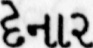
દેનાર
